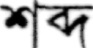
শব্দ
